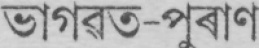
ভাগৱত-পুৰাণ,
